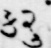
કરું
